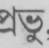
প্ৰভু,
